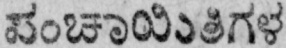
ಪಂಚಾಯಿತಿಗಳ
